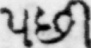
પછી
